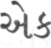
એક
